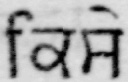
ਕਿਸੇ
